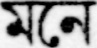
মনে
